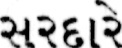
સરદારે
